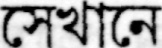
সেখানে
